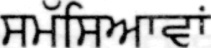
ਸਮੱਸਿਆਵਾਂ
